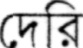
দেরি
